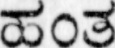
ಹಂತ
